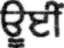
ਊਈਂ
